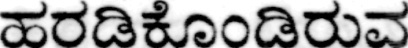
ಹರಡಿಕೊಂಡಿರುವ
